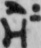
ਮੈਂ
